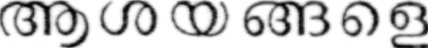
ആശയങ്ങളെ
